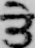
ਤੇ
